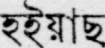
হইয়াছ
